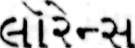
લૉરેન્સ
